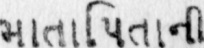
માતાપિતાની
